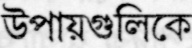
উপায়গুলিকে
